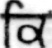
ਕਿ
